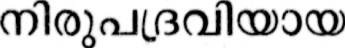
നിരുപദ്രവിയായ
